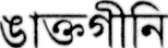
ঙাক্তগীনি
